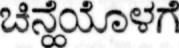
ಚಿನ್ಹೆಯೊಳಗೆ
